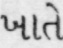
ખાતે
